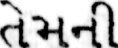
તેમની
